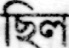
ছিল
